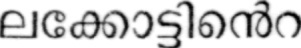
ലക്കോട്ടിന്റെ
